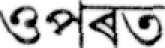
ওপৰত
